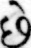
છે
